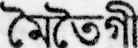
মৈতৈগী
